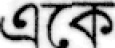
একে
